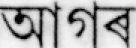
আগৰ
